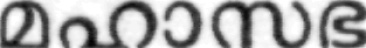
മഹാസഭ
